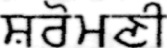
ਸ਼ਰੋਮਣੀ
